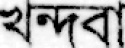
খন্দবা
